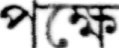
পক্ষে
